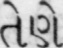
તેણે
